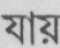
যায়
